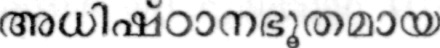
അധിഷ്ഠാനഭൂതമായ
